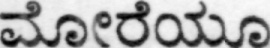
ಮೋರೆಯೂ
